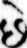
છે
